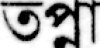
তপ্না
